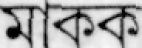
মাকক
